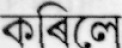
কৰিলে
